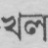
খল
